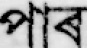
পাৰ
